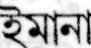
ইমানা
